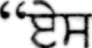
''ਏਸ
